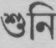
শুনি
